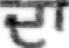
ਦਾ
